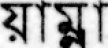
য়াম্না
